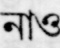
নাও
